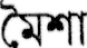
মৈশা
